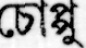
চোপ্পু
